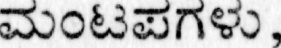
ಮಂಟಪಗಳು,
